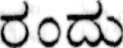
ರಂದು
